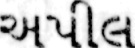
અપીલ
